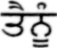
ਤੈਨੂੰ
